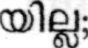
യില്ല;
